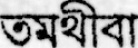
তমথীবা
